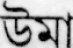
উমা
